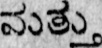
ಮತ್ತು
